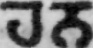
ਹਨ
